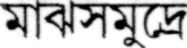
মাঝসমুদ্রে
